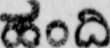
ಹಂದಿ
